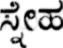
ಸ್ನೇಹ
